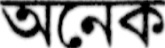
অনেক
